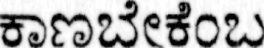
ಕಾಣಬೇಕೆಂಬ
